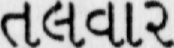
તલવાર
